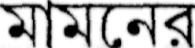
মামনের
